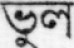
ভুল
